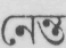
নেন্ত
